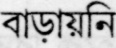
বাড়ায়নি
